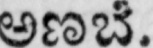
ಅಣಬೆ.
